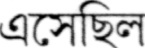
এসেছিল
